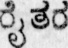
ರೈತರ
